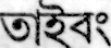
তাইবং
